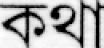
কথা
